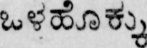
ಒಳಹೊಕ್ಕು
